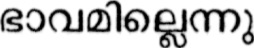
ഭാവമില്ലെന്നു
